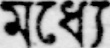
মধ্যে
